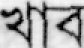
খাব
